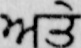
ਅਤੇ
